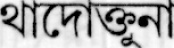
থাদোক্তুনা
